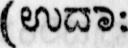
(ಉದಾ:
